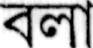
বলা
